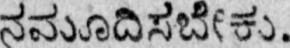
ನಮೂದಿಸಬೇಕು.
